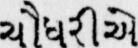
ચૌધરીએ
